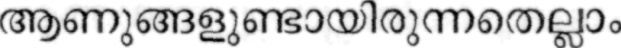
ആണുങ്ങളുണ്ടായിരുന്നതെല്ലാം
